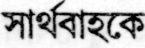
সার্থবাহকে
